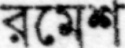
রমেশ
